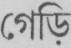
গেড়ি
